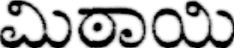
ಮಿಠಾಯಿ
